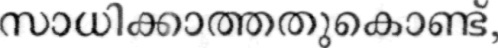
സാധിക്കാത്തതുകൊണ്ട്,
